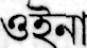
ওইনা
